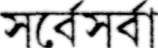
সর্বেসর্বা
